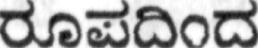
ರೂಪದಿಂದ
